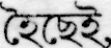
হৈছেই,
